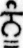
ਨੂੰ
